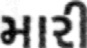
મારી
